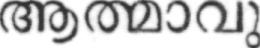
ആത്മാവു
